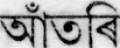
আঁতৰি
